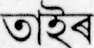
তাইৰ
